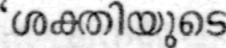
'ശക്തിയുടെ
